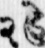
રહે
